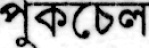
পুকচেল
